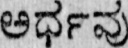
ಅರ್ಧವು
